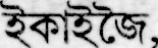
ইকাইজৈ
